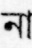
না
